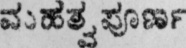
ಮಹತ್ವಪೂರ್ಣ
